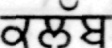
ਕਲੱਬ
